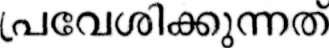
പ്രവേശിക്കുന്നത്
